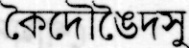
কৈদৌঙৈদসু
